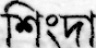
শিংদা
